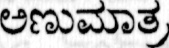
ಅಣುಮಾತ್ರ
